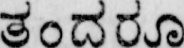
ತಂದರೂ
